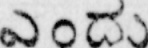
ಎಂದು
